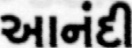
આનંદી
